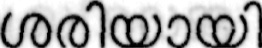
ശരിയായി
